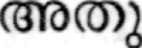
അതു
